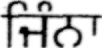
ਜਿੰਨਾ
